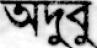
অদুবু
